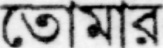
তোমার
